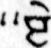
''ਏ
